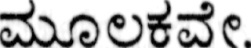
ಮೂಲಕವೇ.
